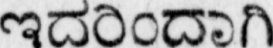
ಇದರಿಂದಾಗಿ
